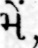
મેં,
